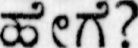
ಹೇಗೆ?
